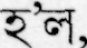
হ'ল,
